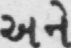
અને
